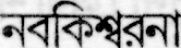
নবকিশ্বরনা
